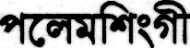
পলেমশিংগী
